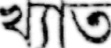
খ্যাত
